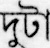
দুটা
